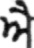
ਐ
